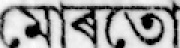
মোৰতো
